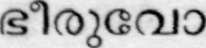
ഭീരുവോ
